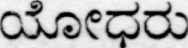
ಯೋಧರು
